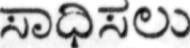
ಸಾಧಿಸಲು
